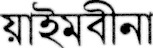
য়াইমবীনা
